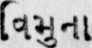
વિમુના
